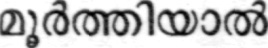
മൂര്‍ത്തിയാല്‍
